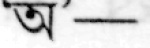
'অ'-
